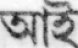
আই
